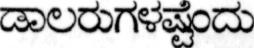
ಡಾಲರುಗಳಷ್ಟೆಂದು
